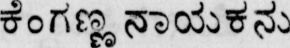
ಕೆಂಗಣ್ಣನಾಯಕನು
